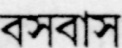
বসবাস
